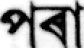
পৰা
